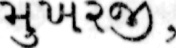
મુખરજી,
